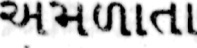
અમળાતા
